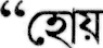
“হোয়
